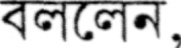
বললেন,
